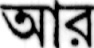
আর
